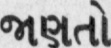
જાણતો
